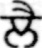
ਲੈ
